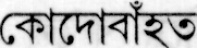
কোদোবাঁহত
